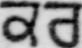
ਕਰ
